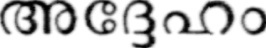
അദ്ദേഹം
